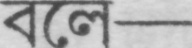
বলে-
